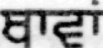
ਥਾਵਾਂ
